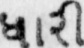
ધારી
